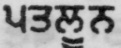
ਪਤਲੂਨ
